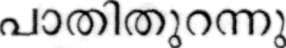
പാതിതുറന്നു
